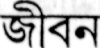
জীবন
